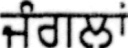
ਜੰਗਲਾਂ
